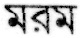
মরম
